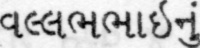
વલ્લભભાઈનું
